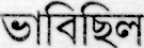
ভাবিছিল
